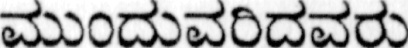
ಮುಂದುವರಿದವರು
